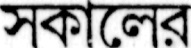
সকালের
